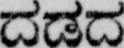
ದಡದ
